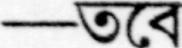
–তবে
